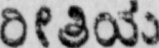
ರೀತಿಯ
